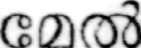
മേല്‍
